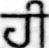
ਹੀ
